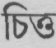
চিত্ত
